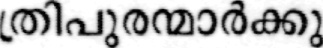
ത്രിപുരന്മാര്‍ക്കു
